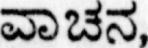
ವಾಚನ,
